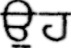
ਉਹ
